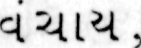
વંચાય,
